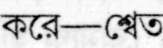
করে–শ্বেত
